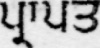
ਪ੍ਰਾਪਤ
